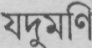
যদুমণি
